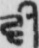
ਵੀ
